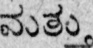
ಮತ್ತು
